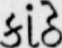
કાંઠે
